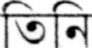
তিনি
